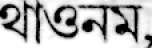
থাওনম,
